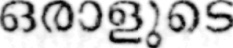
ഒരാളുടെ
